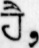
ਹੈ,
